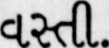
વસ્તી.
